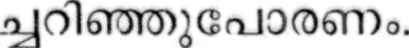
ച്ചറിഞ്ഞുപോരണം.
